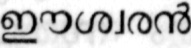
ഈശ്വരന്‍
